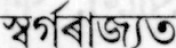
স্বর্গৰাজ্যত
